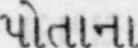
પોતાના
